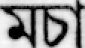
মচা
